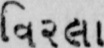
વિરલા
